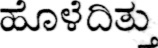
ಹೊಳೆದಿತ್ತು
